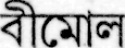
বীমোল
